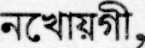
নখোয়গী,
